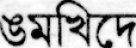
ঙমখিদে
